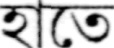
হাতে
